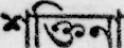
শক্তিনা
